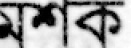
মশক
